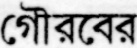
গৌরবের
